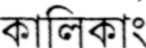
কালিকাং
